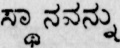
ಸ್ಥಾನವನ್ನು
